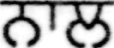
ਨਾਲ
